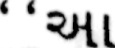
"આ
